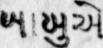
બાબુએ
